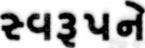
સ્વરૂપને
